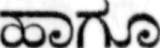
ಹಾಗೂ
